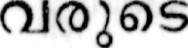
വരുടെ
